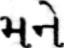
મને
